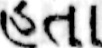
હતા
